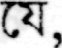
যে,
